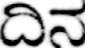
ದಿನ
